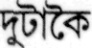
দুটাকৈ
